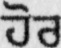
ਹੋਰ
